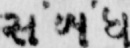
સંબંધ
